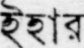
ইহার
